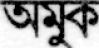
অমুক
